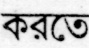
করতে
